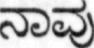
ನಾವು
